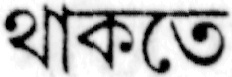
থাকতে
